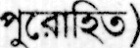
পুরোহিত)
